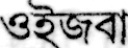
ওইজবা
